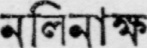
নলিনাক্ষ
